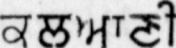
ਕਲਆਣੀ
